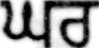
ਘਰ
